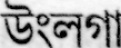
উংলগা
